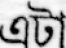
এটা
